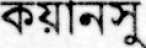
কয়ানসু
